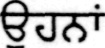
ਉਹਨਾਂ
